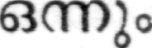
ഒന്നും
